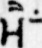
ਮੈਂ
